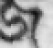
জ
